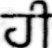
ਹੀ
